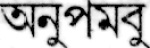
অনুপমবু
